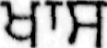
ਖਾਸ
